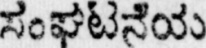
ಸಂಘಟನೆಯ
